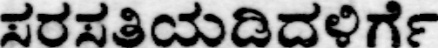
ಸರಸತಿಯಡಿದಳಿರ್ಗೆ
